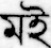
মই
